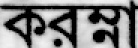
করম্না
